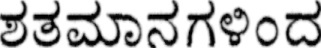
ಶತಮಾನಗಳಿಂದ
